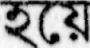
হয়ে
